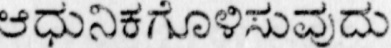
ಆಧುನಿಕಗೊಳಿಸುವುದು
